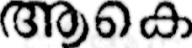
ആകെ
